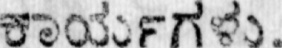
ಕಾರ್ಯಗಳು.
